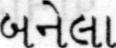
બનેલા
